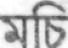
মচি
